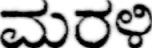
ಮರಳಿ
